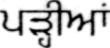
ਪੜ੍ਹੀਆਂ
